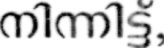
നിന്നിട്ട്,
